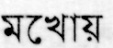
মখোয়
